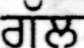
ਗੱਲ
